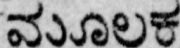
ಮೂಲಕ
